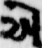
એ
